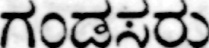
ಗಂಡಸರು
